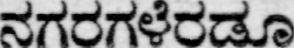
ನಗರಗಳೆರಡೂ
